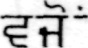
ਵਜੋਂ
